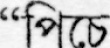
"পিচে
